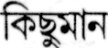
কিছুমান
